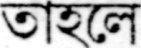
তাহলে
